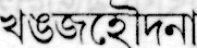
খঙজহৌদনা
